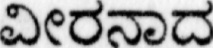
ವೀರನಾದ
